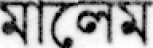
মালেম
